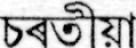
চৰতীয়া
